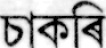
চাকৰি
